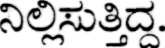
ನಿಲ್ಲಿಸುತ್ತಿದ್ದ.
